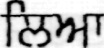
ਲਿਆ
